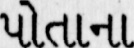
પોતાના
